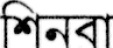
শিনবা
